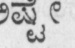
ಅಷ್ಟೇ
